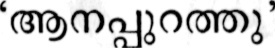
‘ആനപ്പുറത്തു'
